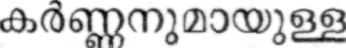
കര്‍ണ്ണനുമായുള്ള
